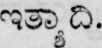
ಇತ್ಯಾದಿ.
